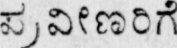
ಪ್ರವೀಣರಿಗೆ
